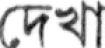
দেখা
